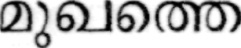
മുഖത്തെ
